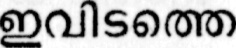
ഇവിടത്തെ
